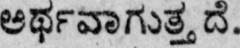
ಅರ್ಥವಾಗುತ್ತದೆ.
